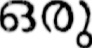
ഒരു
